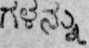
ಗಳನ್ನು
